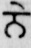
ਨੇ
